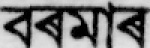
বৰমাৰ
